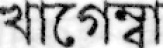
খাগেম্বা
